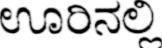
ಊರಿನಲ್ಲಿ
